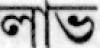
লাভ
